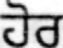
ਹੋਰ
